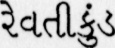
રેવતીકુંડ
